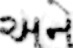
અને
